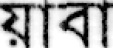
য়াবা
